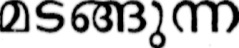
മടങ്ങുന്ന
